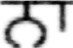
ਨਾ
